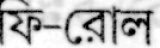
ফি-রোল
